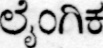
ಲೈಂಗಿಕ
